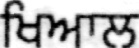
ਖਿਆਲ
